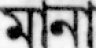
মানা
